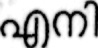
എനി
